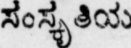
ಸಂಸ್ಕೃತಿಯ
